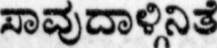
ಸಾವುದಾಳ್ಗಿನಿತೆ
